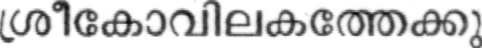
ശ്രീകോവിലകത്തേക്കു
